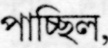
পাচ্ছিল,
